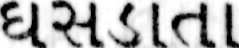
ઘસડાતા
